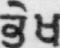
ਭੇਖ
